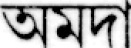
অমদা
